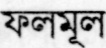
ফলমূল
